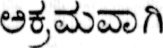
ಅಕ್ರಮವಾಗಿ
